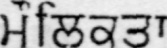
ਮੌਲਿਕਤਾ
